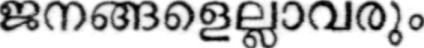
ജനങ്ങളെല്ലാവരും
